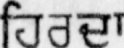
ਹਿਰਦਾ
